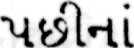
પછીનાં
